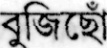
বুজিছোঁ
